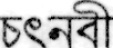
চৎনবী
